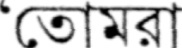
‘তোমরা
